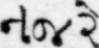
નજરે
